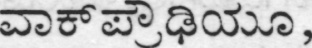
ವಾಕ್‌ಪ್ರೌಢಿಯೂ,
